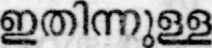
ഇതിന്നുള്ള
